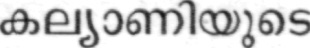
കല്യാണിയുടെ
